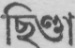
ছিণ্ডা
